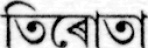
তিৰোতা
